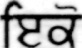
ਇਕੋ
